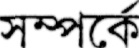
সম্পর্কে
